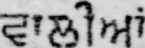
ਵਾਲੀਆਂ
